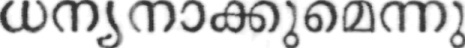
ധന്യനാക്കുമെന്നു
